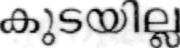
കുടയില്ല
